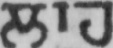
ਲਾਹ
